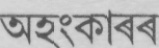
অহংকাৰৰ
